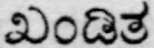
ಖಂಡಿತ
